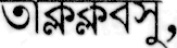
তাক্লক্লবসু,
